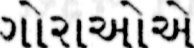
ગોરાઓએ
